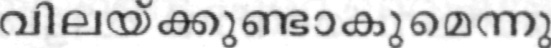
വിലയ്ക്കുണ്ടാകുമെന്നു
